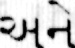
અને
